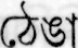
ঠেঙা
